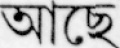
আছে
